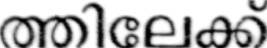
ത്തിലേക്ക്
